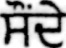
ਸੌਂਦੇ
